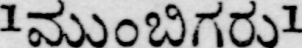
1ಮುಂಬಿಗರು1
